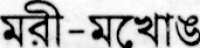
মরী-মখোঙ
